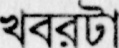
খবরটা
